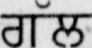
ਗੱਲ
